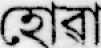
হোৱা
